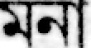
মনা
